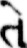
તે
